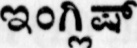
ಇಂಗ್ಲಿಷ್
